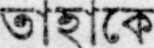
তাহাকে
